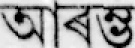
আৰম্ভ
